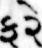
ફરે
